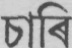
চাৰি
